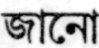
জানো
